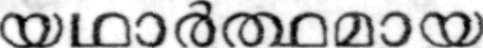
യഥാര്‍ത്ഥമായ
